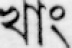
খাং
